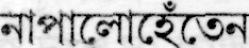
নাপালোহেঁতেন
